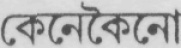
কেনেকৈনো
